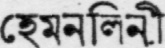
হেমনলিনী
